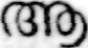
ആ
